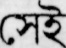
সেই
